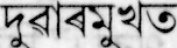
দুৱাৰমুখত
